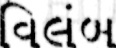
વિલંબ
